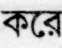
করে
